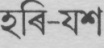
হৰি-যশ
